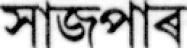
সাজপাৰ
